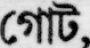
গোট,
